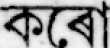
কৰো
